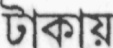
টাকায়
